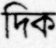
দিক
